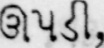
ઊપડી,
